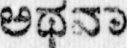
ಅಥವಾ
